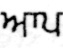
ਆਪ
